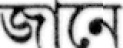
জানে
